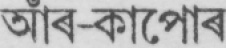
আঁৰ-কাপোৰ
